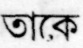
তাকে
